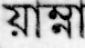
য়াম্না
